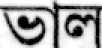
ভাল
